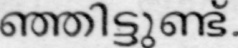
ഞ്ഞിട്ടുണ്ട്.
